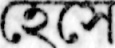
হেসে
